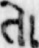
તો
